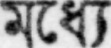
মধ্যে
